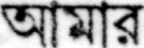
আমার
